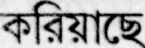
করিয়াছে
